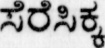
ಸೆರೆಸಿಕ್ಕ
